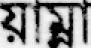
য়াম্না
